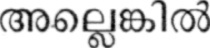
അല്ലെങ്കില്‍
